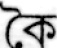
কৈ
